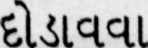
દોડાવવા
